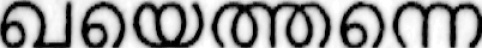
ഖയെത്തന്നെ
